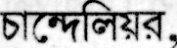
চান্দেলিয়র,
